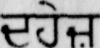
ਦਹੇਜ਼
